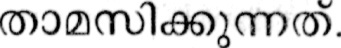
താമസിക്കുന്നത്.
